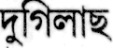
দুগিলাছ
